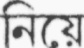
নিয়ে
